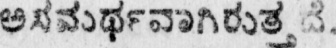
ಅಸಮರ್ಥವಾಗಿರುತ್ತದೆ.
